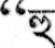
“হু
